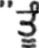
''ਤੂੰ
